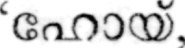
'ഹോയ്,
